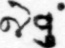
જેવું
